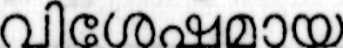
വിശേഷമായ
